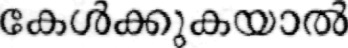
കേള്‍ക്കുകയാല്‍
